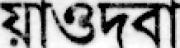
য়াওদবা
